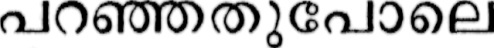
പറഞ്ഞതുപോലെ
